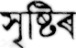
সৃষ্টিৰ
